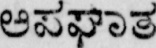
ಅಪಘಾತ
